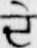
ਦੇ
